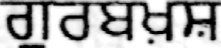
ਗੁਰਬਖ਼ਸ਼
